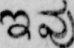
ಇವು
